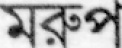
মরুপ
